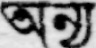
অন্য
